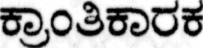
ಕ್ರಾಂತಿಕಾರಕ
